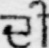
ਦੀ
